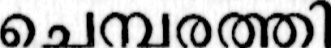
ചെമ്പരത്തി
